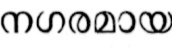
നഗരമായ
